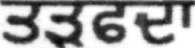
ਤੜਫਦਾ
